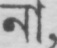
না,
